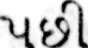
પછી
